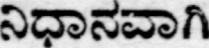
ನಿಧಾನವಾಗಿ
